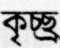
কৃচ্ছ্র
